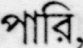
পারি,
